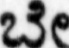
ಬೇ
